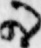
જે
